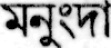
মনুংদা
